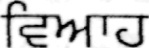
ਵਿਆਹ
